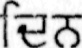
ਦਿਨ
